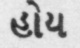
હોય
